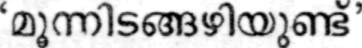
‘മൂന്നിടങ്ങഴിയുണ്ട്’
